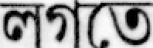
লগতে
